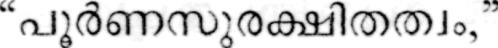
"പൂര്‍ണസുരക്ഷിതത്വം,"
